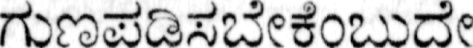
ಗುಣಪಡಿಸಬೇಕೆಂಬುದೇ
